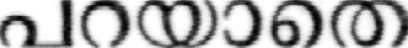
പറയാതെ
